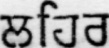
ਲਹਿਰ
